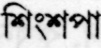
শিংশপা
